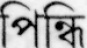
পিন্ধি
